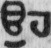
ਉਹ
